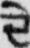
ਦੇ
